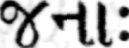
જનાઃ
